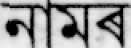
নামৰ
